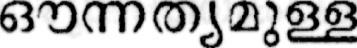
ഔന്നത്യമുള്ള
